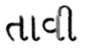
તાવી
